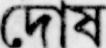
দোষ
